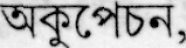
অকুপেচন,
